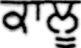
ਕਾਲੂ
